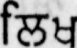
ਲਿਖ
